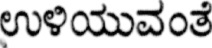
ಉಳಿಯುವಂತೆ
